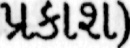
પ્રકાશ)
